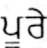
ਪੂਰੇ
